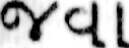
જવા
